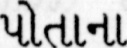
પોતાના
